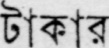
টাকার
